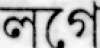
লগে
